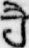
ਹੈ
